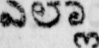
ಎಲ್ಲಾ
